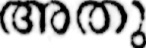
അതു
